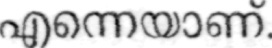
എന്നെയാണ്.
